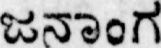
ಜನಾಂಗ
